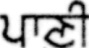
ਪਾਣੀ
